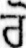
ਰੋ
